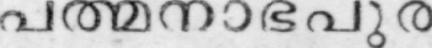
പത്മനാഭപുര
